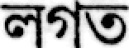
লগত
